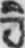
ਹੈ
